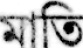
মাতি
